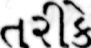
તરીકે
